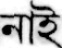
নাই
